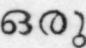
ഒരു
